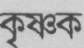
কৃষ্ণক
